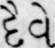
દૈવે
